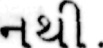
નથી.
